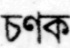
চণক
